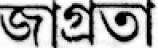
জাগ্রতা
